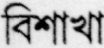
বিশাখা
